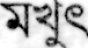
মখুৎ
